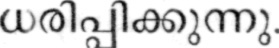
ധരിപ്പിക്കുന്നു.
